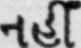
નહીં
